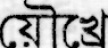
য়ৌখ্রে
